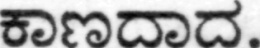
ಕಾಣದಾದ.
